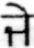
ਜੇ
